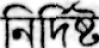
নিৰ্দিষ্ট
